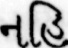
નહિ
